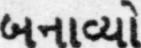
બનાવ્યો
